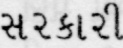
સરકારી
